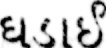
ઘડાઈ
